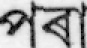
পৰা
